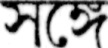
সঙ্গে
